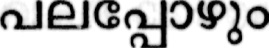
പലപ്പോഴും
